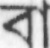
বা
